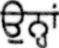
ਉਨ੍ਹਾਂ
